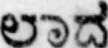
ಲಾದ
